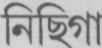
নিছিগা
